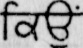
ਕਿਉਂ
